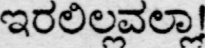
ಇರಲಿಲ್ಲವಲ್ಲಾ!
